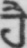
ਹੈ
